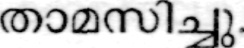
താമസിച്ചു.
